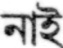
নাই
